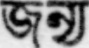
জন্য
